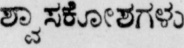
ಶ್ವಾಸಕೋಶಗಳು
